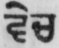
ਵੇਚ
